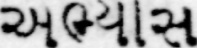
અભ્યાસ
